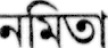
নমিতা
